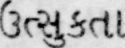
ઉત્સુકતા
